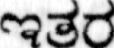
ಇತರ
